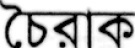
চৈরাক
